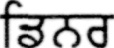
ਡਿਨਰ
